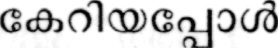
കേറിയപ്പോള്‍
